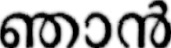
ഞാന്‍
